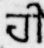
ਹੀ
